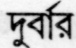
দুর্বার
